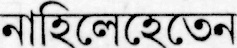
নাহিলেহেতেন
